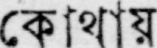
কোথায়
